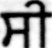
ਸੀ
